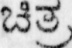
ಚಿತ್ರ
